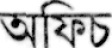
অফিচ
